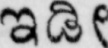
ಇಡೀ
